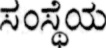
ಸಂಸ್ಥೆಯ
